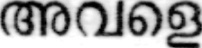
അവളെ
